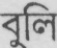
বুলি
